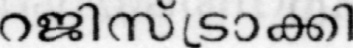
റജിസ്ട്രാക്കി
